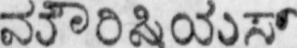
ಮೌರಿಷಿಯಸ್
